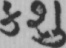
કશુ
